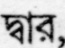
দ্বার,
